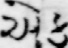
એક
